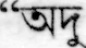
“অদু
